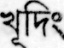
খূদিং
